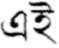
এই
